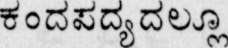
ಕಂದಪದ್ಯದಲ್ಲೂ
